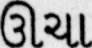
ઊચા
